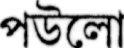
পউলো
